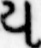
ય
